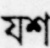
যশ
